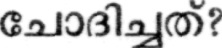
ചോദിച്ചത്?
